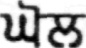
ਘੋਲ
